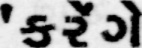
'કરેંગે
